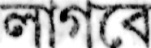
লাগবে
